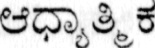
ಆಧ್ಯಾತ್ಮಿಕ
